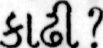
કાઢી?
